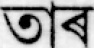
তাৰ
